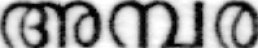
അമ്പര
